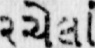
રચેલાં
